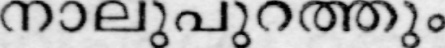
നാലുപുറത്തും
